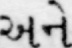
અને
